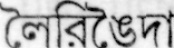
লৈরিঙৈদা
